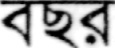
বছর
